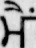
ਮੈਂ
